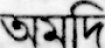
অমদি
